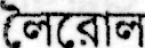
লৈরোল
